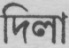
দিলা
